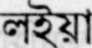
লইয়া
